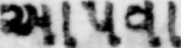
આપવા
